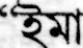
“ইমা
